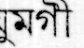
য়ুমগী
